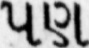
પણ
